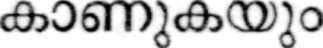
കാണുകയും
